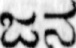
ಜನ
